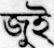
জুই
